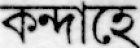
কন্দাহে
